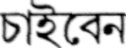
চাইবেন
